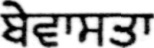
ਬੇਵਾਸਤਾ
